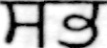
ਸਭ
